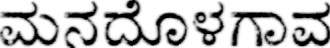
ಮನದೊಳಗಾವ
